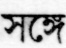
সঙ্গে
